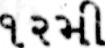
૧૨મી
